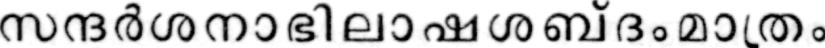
സന്ദര്‍ശനാഭിലാഷശബ്ദംമാത്രം
